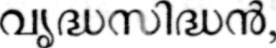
വൃദ്ധസിദ്ധന്‍,
